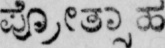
ಪ್ರೋತ್ಸಾಹ
